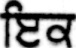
ਇਕ
